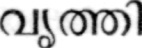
വൃത്തി
